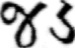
જડ
